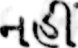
નહીં
